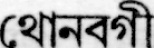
থোনবগী
